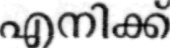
എനിക്ക്
